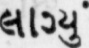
લાગ્યું
